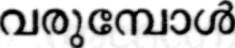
വരുമ്പോള്‍
